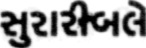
સુરારીબલે
